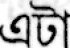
এটা
